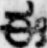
ಈ
